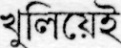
খুলিয়েই
